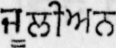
ਜੂਲੀਅਨ
